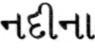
નદીના
